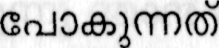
പോകുന്നത്
